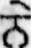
ਨੇ
